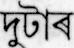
দুটাৰ
